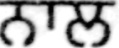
ਨਾਲ
